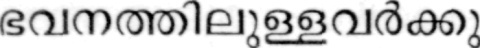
ഭവനത്തിലുള്ളവര്‍ക്കു
